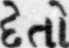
દેતો
